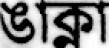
ঙাক্না
